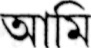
আমি
